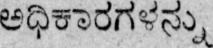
ಅಧಿಕಾರಗಳನ್ನು
